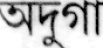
অদুগা
